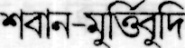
শবান-মুর্ত্তিবুদি
